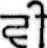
ਵੀ
